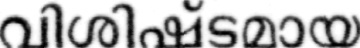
വിശിഷ്ടമായ
